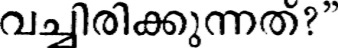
വച്ചിരിക്കുന്നത്?"
